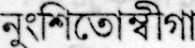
নুংশিতোম্বীগা
